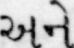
અને
